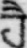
ਹੈ
